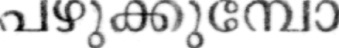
പഴുക്കുമ്പോ
